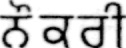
ਨੌਕਰੀ
